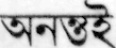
অনন্তই
